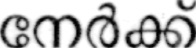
നേര്‍ക്ക്
